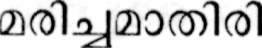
മരിച്ചമാതിരി
